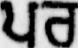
ਪਰ
